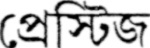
প্রেস্টিজ
